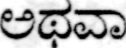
ಅಥವಾ
